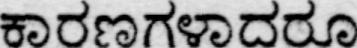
ಕಾರಣಗಳಾದರೂ
